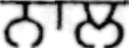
ਨਾਲ
